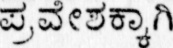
ಪ್ರವೇಶಕ್ಕಾಗಿ
